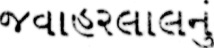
જવાહરલાલનું
